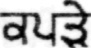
ਕਪੜੇ
